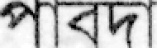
পাবদা
